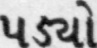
પડ્યો
